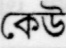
কেউ
